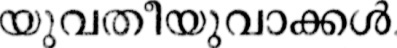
യുവതീയുവാക്കള്‍.
